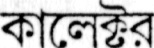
কালেক্টর
